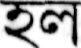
হল
